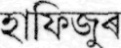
হাফিজুৰ
